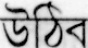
উঠিব
